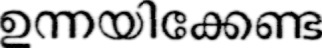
ഉന്നയിക്കേണ്ട
